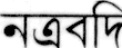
নত্রবদি
